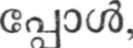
പ്പോള്‍,
